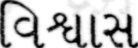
વિશ્વાસ
